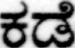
ಕಡೆ
